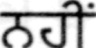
ਨਹੀਂ
